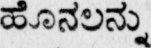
ಹೊನಲನ್ನು
